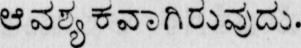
ಆವಶ್ಯಕವಾಗಿರುವುದು.
